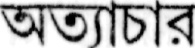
অত্যাচার
